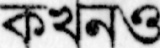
কখনও
